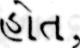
હોત,
